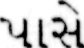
પાસે
